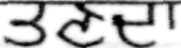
ਤਣਦਾ
